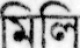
মিলি
